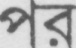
পর
